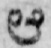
ಆ
